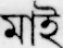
মাই
